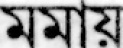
মমায়
